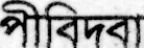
পীবিদবা
